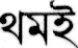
থমই
